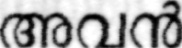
അവന്‍
